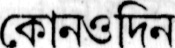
কোনওদিন
